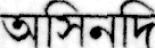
অসিনদি
